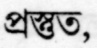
প্রস্তুত,
